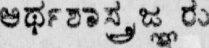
ಅರ್ಥಶಾಸ್ತ್ರಜ್ಞರು
